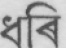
ধৰি
